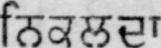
ਨਿਕਲਦਾ
